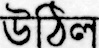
উঠিল
